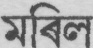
মৰিল
